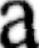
a
